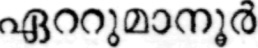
ഏററുമാനൂര്‍
